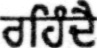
ਰਹਿੰਦੈ
